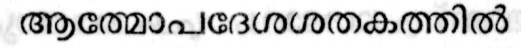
ആത്മോപദേശശതകത്തില്‍
